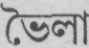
ভৈলা
